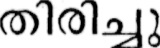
തിരിച്ചു
